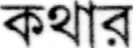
কথার
